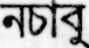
নচাবু
